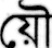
য়ৌ
